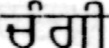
ਚੰਗੀ
